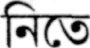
নিতে
